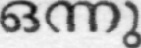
ഒന്നു
